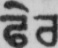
ਫੇਰ
